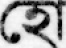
হো
